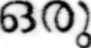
ഒരു
